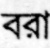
বরা
